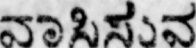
ವಾಸಿಸುವ
